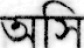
অসি
